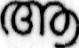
ആ
